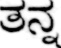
ತನ್ನ
